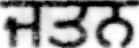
ਜਤਨ
